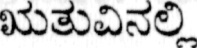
ಋತುವಿನಲ್ಲಿ
